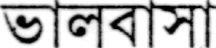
ভালবাসা
